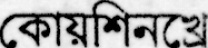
কোয়শিনখ্রে
